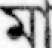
মা
